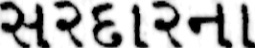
સરદારના
